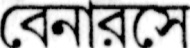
বেনারসে
